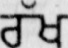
ਰੱਖ
